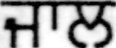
ਜਾਲ
